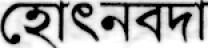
হোৎনবদা
